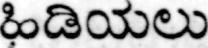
ಹಿಡಿಯಲು
